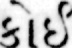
કોઈ
